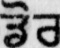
ਡੋਰ
